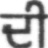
ਦੀ
